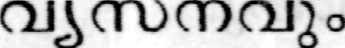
വ്യസനവും
